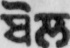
ਬੋਲ
